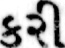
કરી
